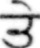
ਤੇ
